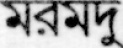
মরমদু
